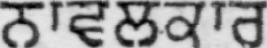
ਨਾਵਲਕਾਰ
